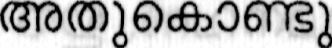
അതുകൊണ്ടു
